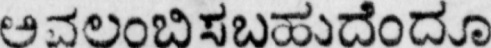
ಅವಲಂಬಿಸಬಹುದೆಂದೂ
